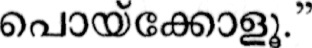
പൊയ്ക്കോളൂ.”
